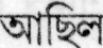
আছিল
